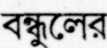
বন্ধুলের
